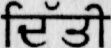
ਦਿੱਤੀ
